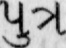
પુત્ર
